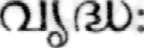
വൃദ്ധ:
